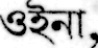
ওইনা,
